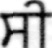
ਸੀ
